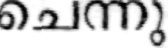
ചെന്നു
